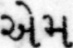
એમ
